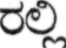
ರಲ್ಲಿ
